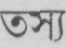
তস্য
